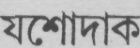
যশোদাক
